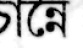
চান্নৈ
